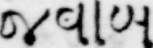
જવાબ
